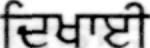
ਦਿਖਾਈ
